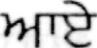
ਆਏ
